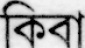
কিবা
